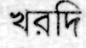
খরদি
